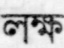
লক্ষ
